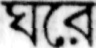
ঘরে
